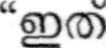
“ഇത്
